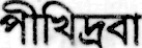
পীখিদ্রবা
